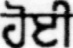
ਹੋਈ
